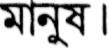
মানুষ।
